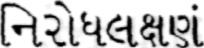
નિરોધલક્ષણં
